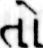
તો
